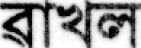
ৱাখল
